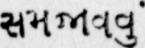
સમજાવવું
